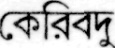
কেরিবদু
